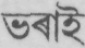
ভৰাই
